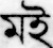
মই
